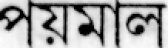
পয়মাল
